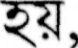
হয়,
